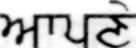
ਆਪਣੇ
